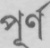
পূৰ্ণ
